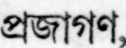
প্রজাগণ,
